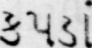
કપડાં
